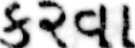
કરવા
